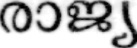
രാജ്യ
